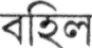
বহিল
